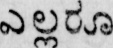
ಎಲ್ಲರೂ
